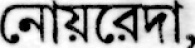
নোয়রেদা,
